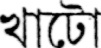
খাটো
